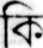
কি
